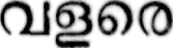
വളരെ
